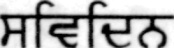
ਸਵਿਦਿਨ
